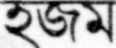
হজম
